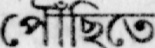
পৌঁছিতে
